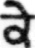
ਕੇ
